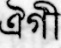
ঐগী
